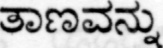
ತಾಣವನ್ನು
